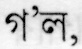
গ'ল,
